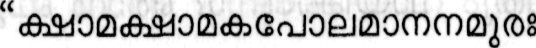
"ക്ഷാമക്ഷാമകപോലമാനനമുരഃ
